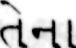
તેના
